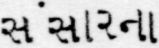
સંસારના
